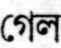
গেল
